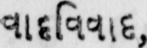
વાદવિવાદ,
